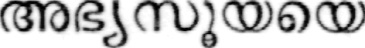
അഭ്യസൂയയെ
